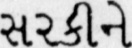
સરકીને
